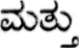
ಮತ್ತು
